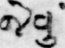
જેવું
